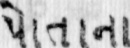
પોતાના
